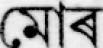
মোৰ
